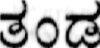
ತಂಡ
